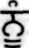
ਨੂੰ
